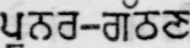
ਪੁਨਰ-ਗੱਠਣ
